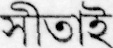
সীতাই
